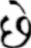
છે
